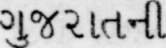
ગુજરાતની
